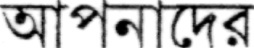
আপনাদের
